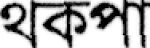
থকপা
